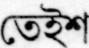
তেইশ
